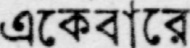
একেবারে
